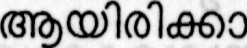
ആയിരിക്കാ
